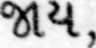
જાય,
